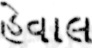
હેવાલ
